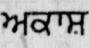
ਅਕਾਸ਼
